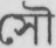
সৌ
